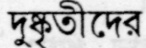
দুষ্কৃতীদের
